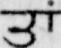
ਤਾਂ
